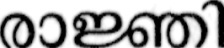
രാജ്ഞി
